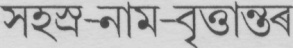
সহস্ৰ-নাম-বৃত্তান্তৰ
